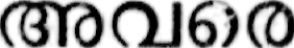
അവരെ
